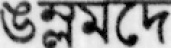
ঙম্লমদে
